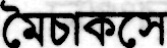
মৈচাকসে
